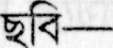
ছবি–
